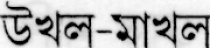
উখল-মাখল
